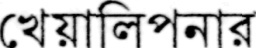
খেয়ালিপনার
